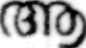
ആ
